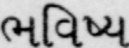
ભવિષ્ય
